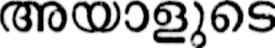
അയാളുടെ
